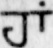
ਹਾਂ
